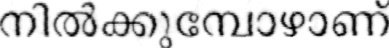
നില്‍ക്കുമ്പോഴാണ്
